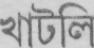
খাটলি
